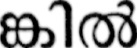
ങ്കില്‍
